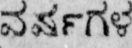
ವರ್ಷಗಳ
